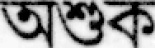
অশুক
